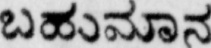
ಬಹುಮಾನ
